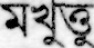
মখুত্তু
